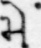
મેં
